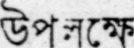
উপলক্ষে
